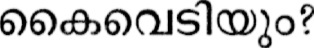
കൈവെടിയും?
